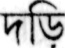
দড়ি
